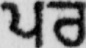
ਪਰ
